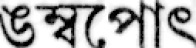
ঙম্বপোৎ
